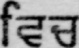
ਵਿਚ
